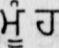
ਮੂੰਹ
